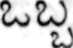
ಒಬ್ಬ
